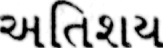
અતિશય
